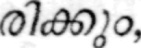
രിക്കും,
